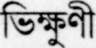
ভিক্ষুণী
